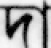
দা
